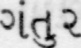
ગંતુર
